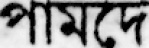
পামদে
